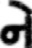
ને
